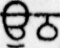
ਉਠ
